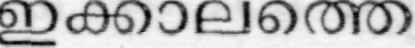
ഇക്കാലത്തെ
